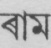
ৰাম
